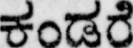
ಕಂಡರೆ
